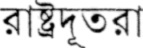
রাষ্ট্রদূতরা
